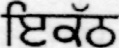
ਇਕੱਠ
